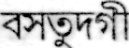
বসতুদগী
